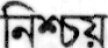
নিশ্চয়
